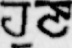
ਹੁਣ
